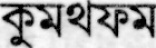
কুমথফম
